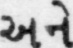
અને
